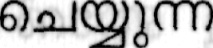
ചെയ്യുന്ന
